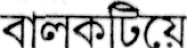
বালকটিয়ে
